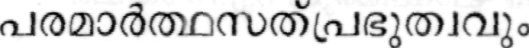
പരമാര്‍ത്ഥസത്പ്രഭുത്വവും
